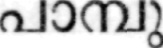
പാമ്പു
